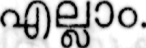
എല്ലാം.
